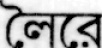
লৈরে
